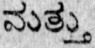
ಮತ್ತು
